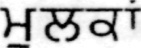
ਮੁਲਕਾਂ
